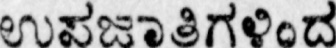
ಉಪಜಾತಿಗಳಿಂದ
